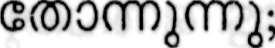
തോന്നുന്നു;
